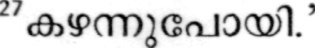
27കഴന്നുപോയി.'
